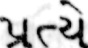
પ્રત્યે
